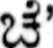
ಚೆ'
